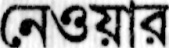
নেওয়ার
